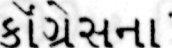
કૉંગ્રેસના
